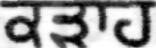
ਕੜਾਹ
